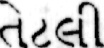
તેટલી
